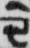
ਦੇ
